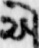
એ
